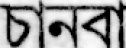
চানবা
